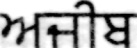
ਅਜੀਬ
